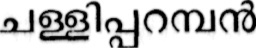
ചള്ളിപ്പറമ്പന്‍
